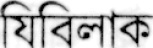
যিবিলাক
